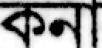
কনা
